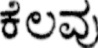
ಕೆಲವು
